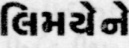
લિમયેને
